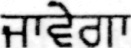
ਜਾਵੇਗਾ
